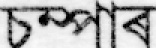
চম্পাৰ
